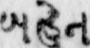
બહેન
